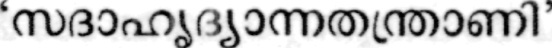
'സദാഹൃദ്യാന്നതന്ത്രാണി'
